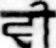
ਵੀ
